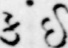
કંઈ
